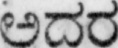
ಅದರ
